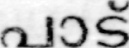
പാട്
